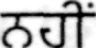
ਨਹੀਂ
